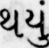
થયું
